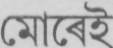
মোৰেই
